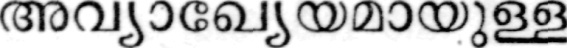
അവ്യാഖ്യേയമായുള്ള
